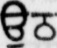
ਉਠ
